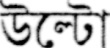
উল্টো
